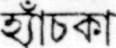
হ্যাঁচকা
